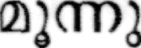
മൂന്നു
